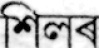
শিলৰ
